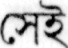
সেই
